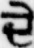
ਦੇ
